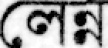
লেন্ন
